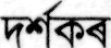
দর্শকৰ
